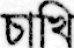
চাখি
